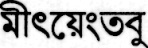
মীৎয়েংতবু
